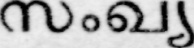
സംഖ്യ
